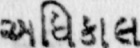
અધિકાલ
